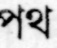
পথ
